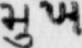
મુખ
